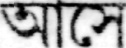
আসে
